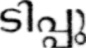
ടിപ്പു
